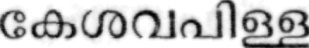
കേശവപിള്ള
